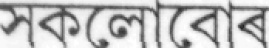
সকলোবোৰ
